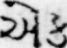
એક
